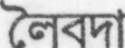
লৈবদা
